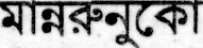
মান্নরুনুকো
